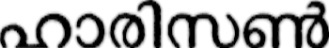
ഹാരിസണ്‍
